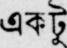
একটু
